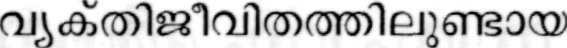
വ്യക്തിജീവിതത്തിലുണ്ടായ
